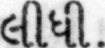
લીધી.
